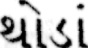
થોડાં
